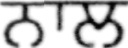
ਨਾਲ
